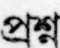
প্রশ্ন
